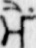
ਮੈਂ
